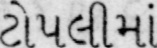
ટોપલીમાં
